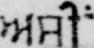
ਅਸੀਂ
